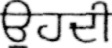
ਉਹਦੀ
